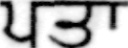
ਪਤਾ
